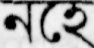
নহে
